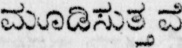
ಮೂಡಿಸುತ್ತವೆ
